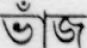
ভাঁজ
